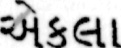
એકલા
